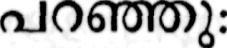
പറഞ്ഞു:
